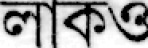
লাকও
